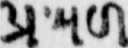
પ્રબળ
